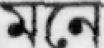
মনে
